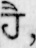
ਹੈ,
